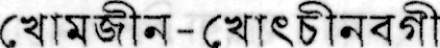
খোমজীন-খোৎচীনবগী
